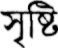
সৃষ্টি
